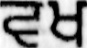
ਵਖ
